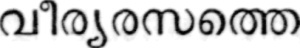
വീര്യരസത്തെ
